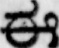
ಈ
